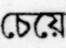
চেয়ে
